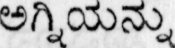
ಅಗ್ನಿಯನ್ನು
